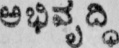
ಅಭಿವೃದ್ಧಿ
